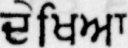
ਦੇਖਿਆ
